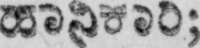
ಹಾನಿಕಾರಿ;
